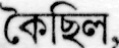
কৈছিল,
